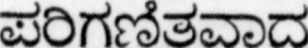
ಪರಿಗಣಿತವಾದ
